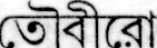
তৌবীরো
